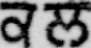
ਕਲ
